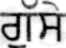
ਗੁੱਸੇ
